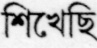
শিখেছি
